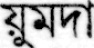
য়ুমদা
